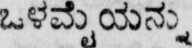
ಒಳಮೈಯನ್ನು
